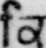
ਕਿ
